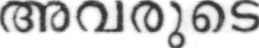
അവരുടെ
